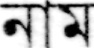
নাম
